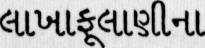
લાખાફૂલાણીના
